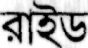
রাইড
